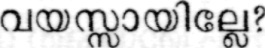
വയസ്സായില്ലേ?
